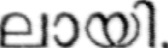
ലായി.
